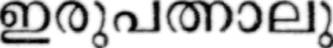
ഇരുപത്നാലു
